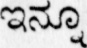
ಇನ್ನೂ
